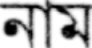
নাম
